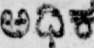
ಅಧಿಕ
